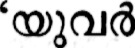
'യുവര്‍
